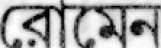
রোমেন
